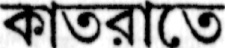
কাতরাতে
